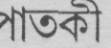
পাতকী
